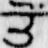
ਤੋਂ
